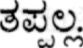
ತಪ್ಪಲ್ಲ.
